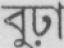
বুঢ়া
